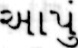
આપું
